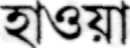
হাওয়া
